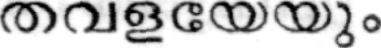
തവളയേയും
